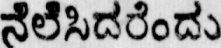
ನೆಲೆಸಿದರೆಂದು
